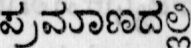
ಪ್ರಮಾಣದಲ್ಲಿ
